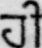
ਹੀ
